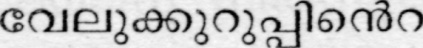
വേലുക്കുറുപ്പിന്റെ
